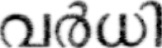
വര്‍ധി
